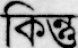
কিন্তু
